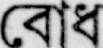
বোধ
